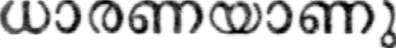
ധാരണയാണു
